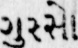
ગુસ્સો
